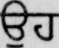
ਉਹ
